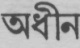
অধীন
